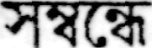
সম্বন্ধে
